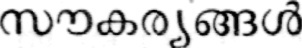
സൌകര്യങ്ങള്‍
